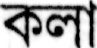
কলা
